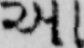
આ
